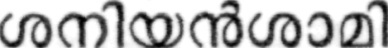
ശനിയന്‍ശാമി
